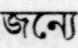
জন্যে
